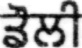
ਡੌਲੀ
